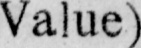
value)
